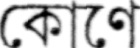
কোণে
